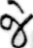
જે
